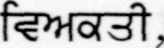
ਵਿਅਕਤੀ,
